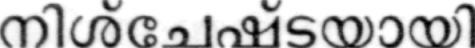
നിശ്ചേഷ്ടയായി
